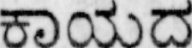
ಕಾಯದ
